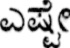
ಎಷ್ಟೇ
